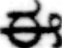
ಈ
